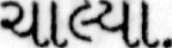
ચાલ્યા.
